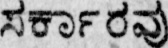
ಸರ್ಕಾರವು
